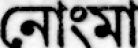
নোংমা
